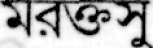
মরক্তসু
